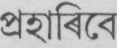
প্রহাৰিবে
